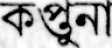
কপ্তুনা
